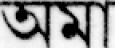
অমা
